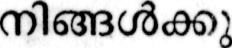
നിങ്ങള്‍ക്കു
